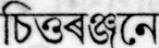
চিত্তৰঞ্জনে
